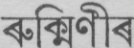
ৰুক্মিণীৰ
